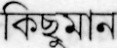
কিছুমান
